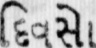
દિવસો
